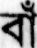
বাঁ
